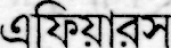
এফিয়ারস
